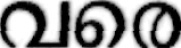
വരെ
